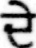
ਦੇ
